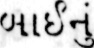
બાઈનું
